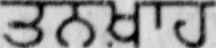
ਤਨਖ਼ਾਹ
